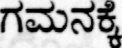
ಗಮನಕ್ಕೆ
